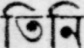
তিনি
